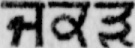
ਜਕੜ
